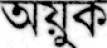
অয়ুক
